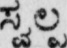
ಸ್ವಲ್ಪ
